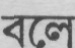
বলে
